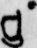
તું
